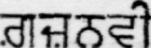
ਗ਼ਜ਼ਨਵੀ
